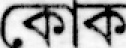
কোক
